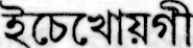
ইচেখোয়গী
